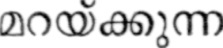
മറയ്ക്കുന്ന
